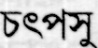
চৎপসু
